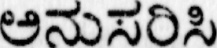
ಅನುಸರಿಸಿ
